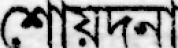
শোয়দনা
